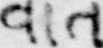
વાત
